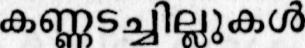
കണ്ണടച്ചില്ലുകള്‍
